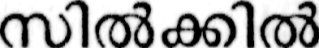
സില്‍ക്കില്‍
